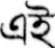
এই
